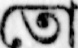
তো
